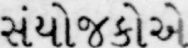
સંયોજકોએ
